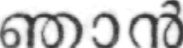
ഞാന്‍
